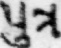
પુત્ર
